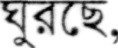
ঘুরছে,
